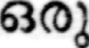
ഒരു
